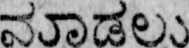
ಮಾಡಲು
